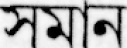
সমান
